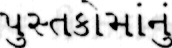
પુસ્તકોમાંનું
